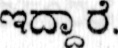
ಇದ್ದಾರೆ.
